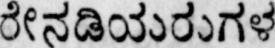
ರೇನಡಿಯರುಗಳ
